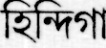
হিন্দিগা
